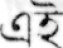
এই
